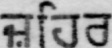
ਜ਼ਹਿਰ
